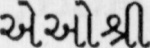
એઓશ્રી
